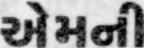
એમની
